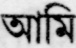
আমি
